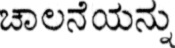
ಚಾಲನೆಯನ್ನು
